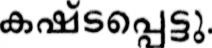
കഷ്ടപ്പെട്ടു.
